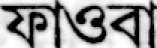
ফাওবা
